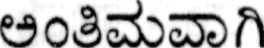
ಅಂತಿಮವಾಗಿ
